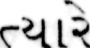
ત્યારે
